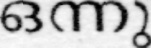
ഒന്നു
